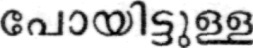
പോയിട്ടുള്ള
